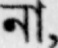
না,
